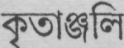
কৃতাঞ্জলি
